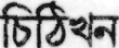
চিঠিখন
